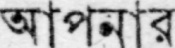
আপনার
